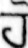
ਹੋ
